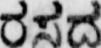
ರಸದ
